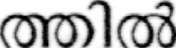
ത്തില്‍
